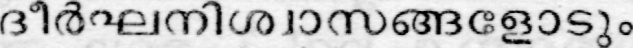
ദീര്‍ഘനിശ്വാസങ്ങളോടും
